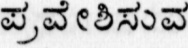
ಪ್ರವೇಶಿಸುವ
